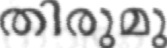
തിരുമു
